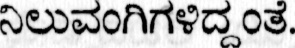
ನಿಲುವಂಗಿಗಳಿದ್ದಂತೆ.
